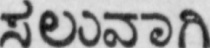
ಸಲುವಾಗಿ
